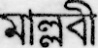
মাল্লবী
